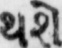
થશે
